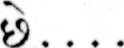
છે....
